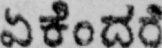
ಏಕೆಂದರೆ
